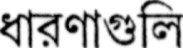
ধারণাগুলি
